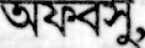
অফবসু,
